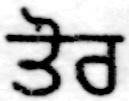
ਤੌਰ
